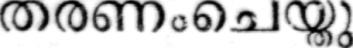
തരണംചെയ്തു
